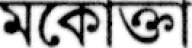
মকোক্তা
